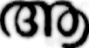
ആ
